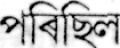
পৰিছিল
